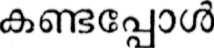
കണ്ടപ്പോള്‍
